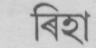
ৰিহা
